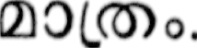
മാത്രം.
